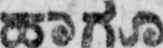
ಹಾಗೂ
